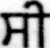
ਸੀ
